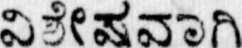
ವಿಶೇಷವಾಗಿ
